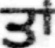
ਤਾਂ
